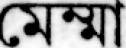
মেম্মা
